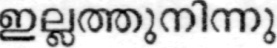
ഇല്ലത്തുനിന്നു
